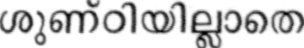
ശുണ്ഠിയില്ലാതെ
